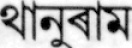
থানুৰাম
